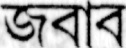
জবাব
